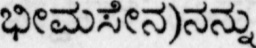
(ಭೀಮಸೇನ)ನನ್ನು
